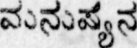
ಮನುಷ್ಯನ
